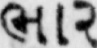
ભાર
